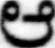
ಆ
